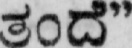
ತಂದೆ”
